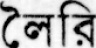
লৈরি
